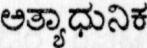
ಅತ್ಯಾಧುನಿಕ
